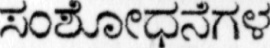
ಸಂಶೋಧನೆಗಳ
